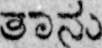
ತಾನು
